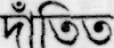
দাঁতিত
